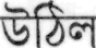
উঠিল
